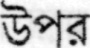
উপর
